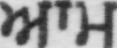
ਆਮ
